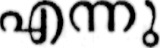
എന്നു
